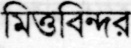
মিত্তবিন্দর
